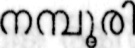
നമ്പൂരി
